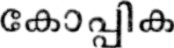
കോപ്പിക
